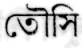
তৌসি
